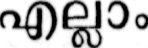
എല്ലാം
